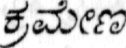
ಕ್ರಮೇಣ
